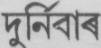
দুৰ্নিবাৰ
